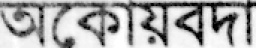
অকোয়বদা
